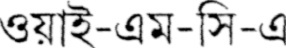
ওয়াই-এম-সি-এ
